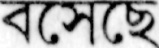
বসেছে
